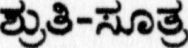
ಶ್ರುತಿ-ಸೂತ್ರ
